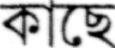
কাছে
